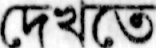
দেখতে
